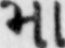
મા
